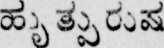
ಹೃತ್ಪುರುಷ
